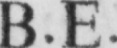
B.E.
